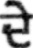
ਦੇ
